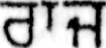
ਰਾਜ
